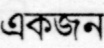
একজন
